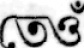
তেওঁ
